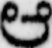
ಆ
